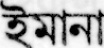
ইমানা
